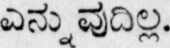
ಎನ್ನುವುದಿಲ್ಲ.
